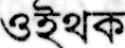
ওইথক
